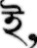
ই,
